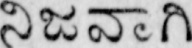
ಜವಾಗಿ
